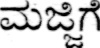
ಮಜ್ಜಿಗೆ
